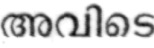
അവിടെ
